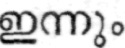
ഇന്നും
